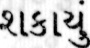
શકાયું
